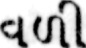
વળી
